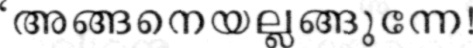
'അങ്ങനെയല്ലങ്ങുന്നേ!
